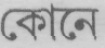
কোনে
